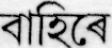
বাহিৰে
